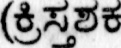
(ಕ್ರಿಸ್ತಶಕ
